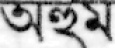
অহুম
